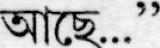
আছে..."
